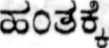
ಹಂತಕ್ಕೆ
